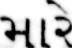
મારે
